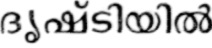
ദൃഷ്ടിയില്‍
